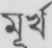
মূর্খ
